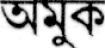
অমুক
